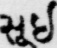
સૂઈ
